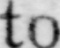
to
